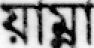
য়াম্না
